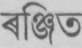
ৰঞ্জিত
